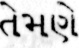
તેમણે
